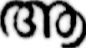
ആ
